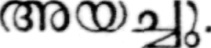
അയച്ചു.
